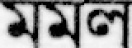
মমল
